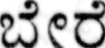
ಬೇರೆ
